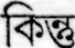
কিন্তু
